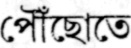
পৌঁছোতে
